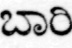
ಬಾರಿ
